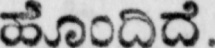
ಹೊಂದಿದೆ.
